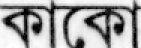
কাকো
